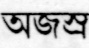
অজস্র
